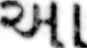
આ
